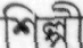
শিল্পী
